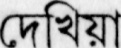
দেখিয়া
